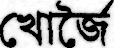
খোর্জৈ
